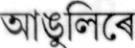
আঙুলিৰে
